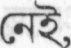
নেই,
